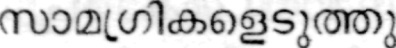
സാമഗ്രികളെടുത്തു
